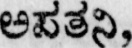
ಅಪತನಿ,
